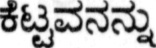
ಕೆಟ್ಟವನನ್ನು
